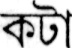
কটা
